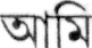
আমি
